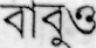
বাবুও
